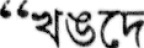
“খঙদে
